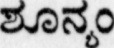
ಶೂನ್ಯಂ
